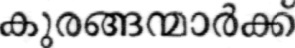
കുരങ്ങന്മാര്‍ക്ക്
